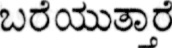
ಬರೆಯುತ್ತಾರೆ
